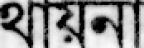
থায়না
